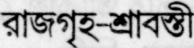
রাজগৃহ-শ্রাবস্তী
